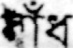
বাঁধ
